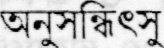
অনুসন্ধিৎসু
